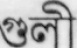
গুলী
